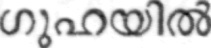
ഗുഹയില്‍
